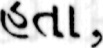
હતા,
